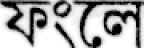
ফংলে
